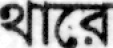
থারে
